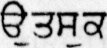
ਉਤਸੁਕ
